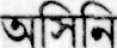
অসিনি
